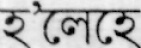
হ'লেহে
